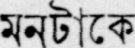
মনটাকে
